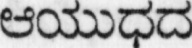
ಆಯುಧದ
